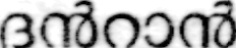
ദന്റാന്‍
